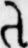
તે
